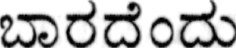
ಬಾರದೆಂದು
